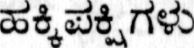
ಹಕ್ಕಿಪಕ್ಷಿಗಳು
